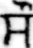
ਸੌ
